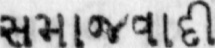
સમાજવાદી
